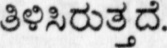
ತಿಳಿಸಿರುತ್ತದೆ.
